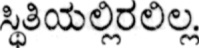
ಸ್ಥಿತಿಯಲ್ಲಿರಲಿಲ್ಲ.
